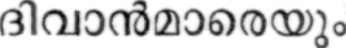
ദിവാന്‍മാരെയും
